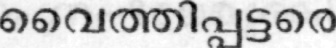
വൈത്തിപ്പട്ടരെ
